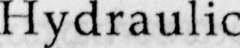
Hydraulic
